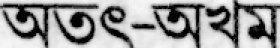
অতৎ-অখম
